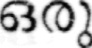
ഒരു
